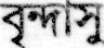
বৃন্দাসু
